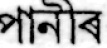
পানীৰ
